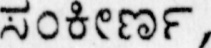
ಸಂಕೀರ್ಣ,
